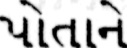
પોતાને
